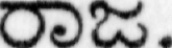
ರಾಜ.
